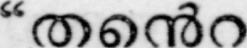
"തന്റെ
